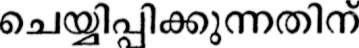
ചെയ്യിപ്പിക്കുന്നതിന്
